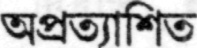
অপ্রত্যাশিত
